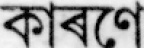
কাৰণে
